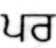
ਪਰ
